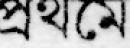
প্রথমে
